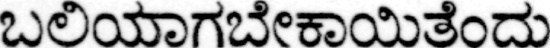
ಬಲಿಯಾಗಬೇಕಾಯಿತೆಂದು
